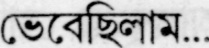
ভেবেছিলাম...
